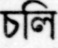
চলি
